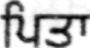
ਪਿਤਾ
